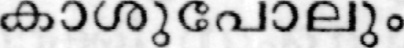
കാശുപോലും
